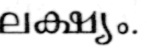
ലക്ഷ്യം.
